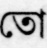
তো
